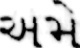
અમે
